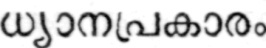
ധ്യാനപ്രകാരം
